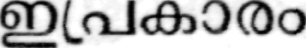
ഇപ്രകാരം
